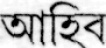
আহিব
